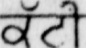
ਕੱਟੀ
